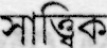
সাত্বিক
